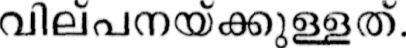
വില്പനയ്ക്കുള്ളത്.
